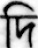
দি
